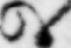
જ
